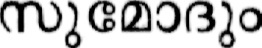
സുമോദും
